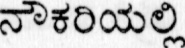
ನೌಕರಿಯಲ್ಲಿ
